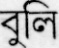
বুলি
